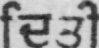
ਦਿਤੀ
